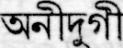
অনীদুগী
